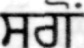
ਸਗੋਂ
